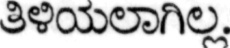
ತಿಳಿಯಲಾಗಿಲ್ಲ.
